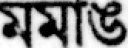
মমাঙ
